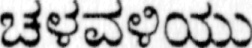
ಚಳವಳಿಯು
